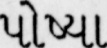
પોષ્યા
